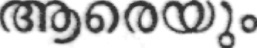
ആരെയും
